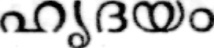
ഹൃദയം
